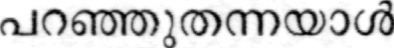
പറഞ്ഞുതന്നയാള്‍
